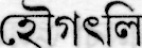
হৌগৎলি
